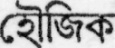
হৌজিক
